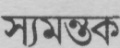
স্যমন্তক
